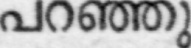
പറഞ്ഞു
